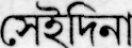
সেইদিনা
